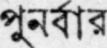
পুনর্বার
